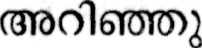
അറിഞ്ഞു
